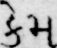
કેમ
